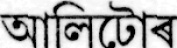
আলিটোৰ
